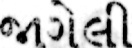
જાગેલી
